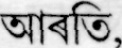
আৰতি,
